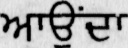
ਆਉਂਦਾ
